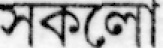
সকলো
